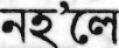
নহ'লে
